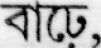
বাঢ়ে,
